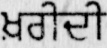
ਖ਼ਰੀਦੀ
